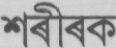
শৰীৰক
